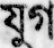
যুগ
